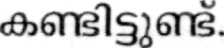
കണ്ടിട്ടുണ്ട്.
